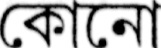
কোনো
